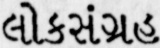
લોકસંગ્રહ
